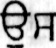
ਉਸ
